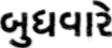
બુધવારે
